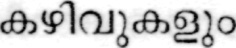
കഴിവുകളും
